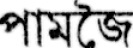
পামজৈ
